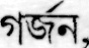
গর্জন,
